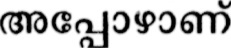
അപ്പോഴാണ്
